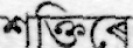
শক্তিৰে
